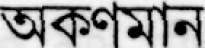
অকণমান
